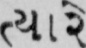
ત્યારે
